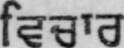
ਵਿਚਾਰ
